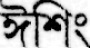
ঈশিং
